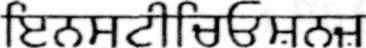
ਇਨਸਟੀਚਿਓਸ਼ਨਜ਼
